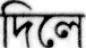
দিলে
